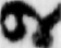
જ
